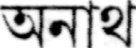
অনাথ
